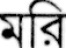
মরি
